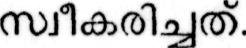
സ്വീകരിച്ചത്.
